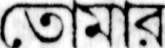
তোমার
